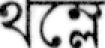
থম্লে
